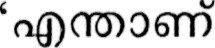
‘എന്താണ്
